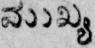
ಮುಖ್ಯ
